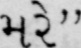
મરે"
